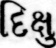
દિક્ષુ
